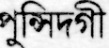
পুন্সিদগী
